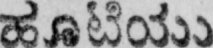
ಹೂಟೆಯು
